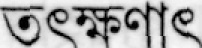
তৎক্ষণাৎ
